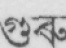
গুৰু
